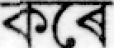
কৰে
